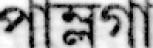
পাম্লগা
